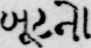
બૂટનો
